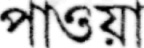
পাওয়া
